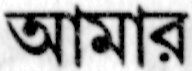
আমার
